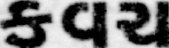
કવચ
